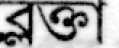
ব্লেক্তা
